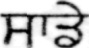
ਸਾਡੇ
